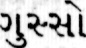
ગુસ્સો
